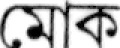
মোক
